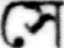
সে
